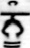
ਨੂੰ
